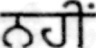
ਨਹੀਂ
